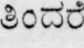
ತಿಂದರೆ
